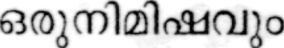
ഒരുനിമിഷവും
